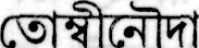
তোম্বীনৌদা
